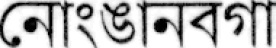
নোংঙানবগা
